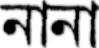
নানা
